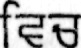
ਵਿਚ
